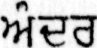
ਅੰਦਰ
